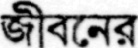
জীবনের
